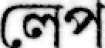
লেপ
